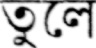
তুলে
